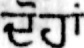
ਦੋਹਾਂ
